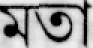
মতা
